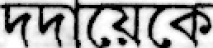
দদায়েকে
